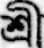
শ্রী
